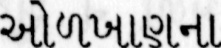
ઓળખાણના
